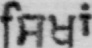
ਸਿਖਾਂ
